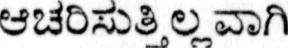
ಆಚರಿಸುತ್ತಿಲ್ಲವಾಗಿ
